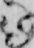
છે
